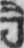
ਹੈ
